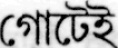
গোটেই
